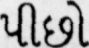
પીછો
